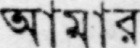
আমার
